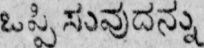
ಒಪ್ಪಿಸುವುದನ್ನು
